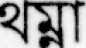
থম্না
